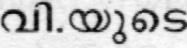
വി.യുടെ
